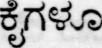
ಕೈಗಳೂ
